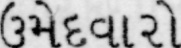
ઉમેદવારો
